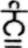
ਨੂੰ
